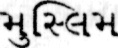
મુસ્લિમ
